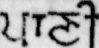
ਪਾਣੀ
